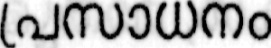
പ്രസാധനം
